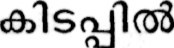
കിടപ്പില്‍
